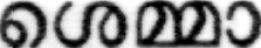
ശെമ്മാ
